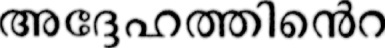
അദ്ദേഹത്തിന്റെ
